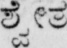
ಶ್ವೇತ
